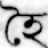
হৈ
